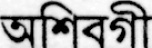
অশিবগী
